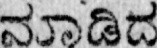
ಮಾಡಿದ
